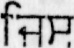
ਜਿਸ
